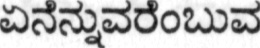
ಏನೆನ್ನುವರೆಂಬುವ
